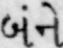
બંને
